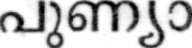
പുണ്യാ
